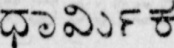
ಧಾರ್ಮಿಕ
